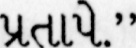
પ્રતાપે."
